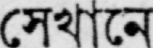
সেখানে
